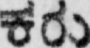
ಕರು
